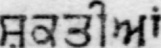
ਸ਼ਕਤੀਆਂ
